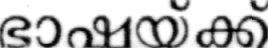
ഭാഷയ്ക്ക്
